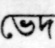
ভেদ
